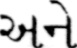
અને
